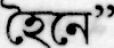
হৈনে”
